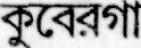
কুবেরগা
